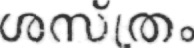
ശസ്ത്രം
